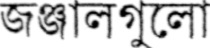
জঞ্জালগুলো
